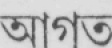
আগত
